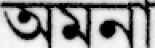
অমনা
